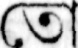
তো
